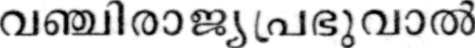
വഞ്ചിരാജ്യപ്രഭുവാല്‍
